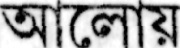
আলোয়
